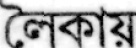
লৈকায়
